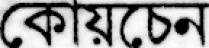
কোয়চেন
